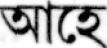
আহে
